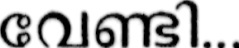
വേണ്ടി...
